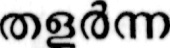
തളര്‍ന്ന
